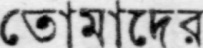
তোমাদের
